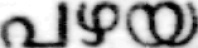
പഴയ
